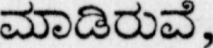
ಮಾಡಿರುವೆ,
